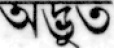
অদ্ভুত
